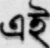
এই
